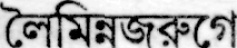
লৈমিন্নজরুগে
